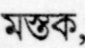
মস্তক,
